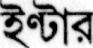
ইণ্টার
